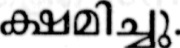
ക്ഷമിച്ചു.
